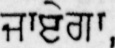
ਜਾਏਗਾ,
